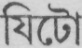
যিটো
